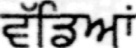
ਵੱਡਿਆਂ
